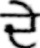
ਦੇ
